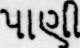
પાણી
